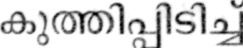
കുത്തിപ്പിടിച്ച്
